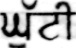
ਘੁੱਟੀ
